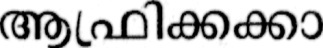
ആഫ്രിക്കക്കാ
